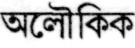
অলৌকিক
